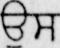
ਉਸ
